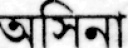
অসিনা
